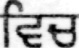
ਵਿਚ
